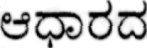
ಆಧಾರದ
